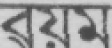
ৱয়ম
